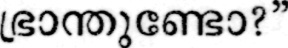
ഭ്രാന്തുണ്ടോ?"
